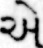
એ
